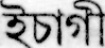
ইচাগী
